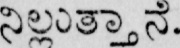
ನಿಲ್ಲುತ್ತಾನೆ.
